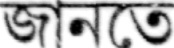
জানতে
